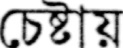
চেষ্টায়
